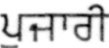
ਪੁਜਾਰੀ
